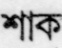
শাক
